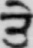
ਤੇ
